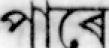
পাৰে
